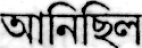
আনিছিল
